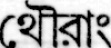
থৌরাং
